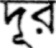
দূর
